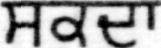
ਸਕਦਾ
